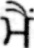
ਮੈਂ
